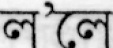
ল'লে
